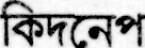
কিদনেপ
